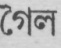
গৈল
